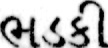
ભડકી
